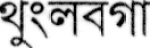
থুংলবগা
